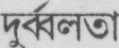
দুৰ্ব্বলতা
